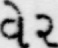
વેર
